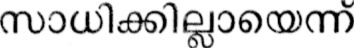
സാധിക്കില്ലായെന്ന്
